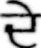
ਦੇ
